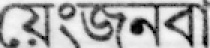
য়েংজনবা
